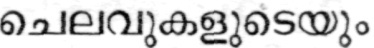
ചെലവുകളുടെയും
